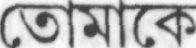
তোমাকে
